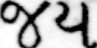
જય
